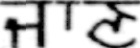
ਜਾਣ
